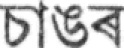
চাঙৰ
